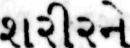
શરીરને
